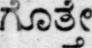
ಗೊತ್ತೇ
